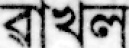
ৱাখল
